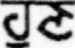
ਹੁਣ
